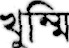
খুম্মি
